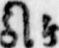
ઠીક
